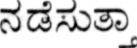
ನಡೆಸುತ್ತಾ
